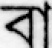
বা
